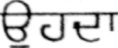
ਉਹਦਾ
